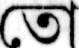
তো
